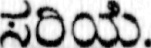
ಸರಿಯೆ.
